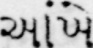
આંખે
